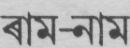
ৰাম-নাম
